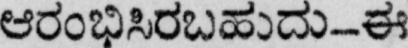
ಆರಂಭಿಸಿರಬಹುದು-ಈ
